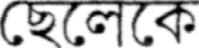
ছেলেকে
